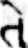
તે
